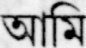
আমি
